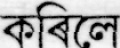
কৰিলে
